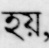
হয়,
